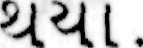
થયા.
